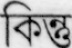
কিন্তু
